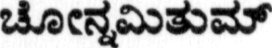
ಚೋನ್ನಮಿತುಮ್
